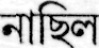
নাছিল
